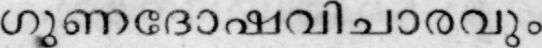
ഗുണദോഷവിചാരവും
